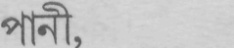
পানী,
